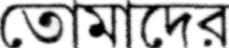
তোমাদের
